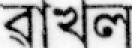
ৱাখল
